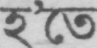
হ'তে
